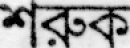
শরুক
